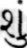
શું
